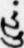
હું
